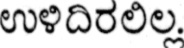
ಉಳಿದಿರಲಿಲ್ಲ.
